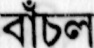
বাঁচল
